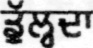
ਡੁੱਲ੍ਹਦਾ
